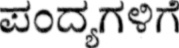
ಪಂದ್ಯಗಳಿಗೆ
